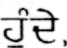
ਹੁੰਦੇ,
